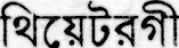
থিয়েটরগী
